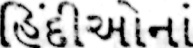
હિંદીઓનાં
